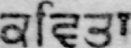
ਕਵਿਤਾ
